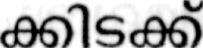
ക്കിടക്ക്
